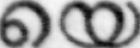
യെ
